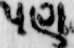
પણ
